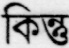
কিন্তু
